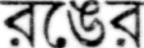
রঙের
